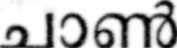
ചാണ്‍
